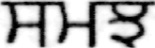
ਸਮਝ
